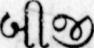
બીજી
